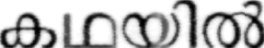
കഥയില്‍
